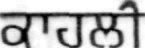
ਕਾਹਲੀ
